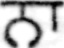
ਨਾ
